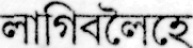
লাগিবলৈহে
